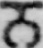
ਨ
